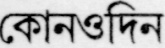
কোনওদিন
